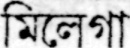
মিলেগা
